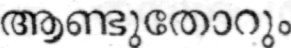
ആണ്ടുതോറും
